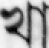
খা
